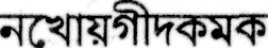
নখোয়গীদমক
